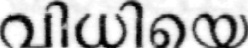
വിധിയെ
